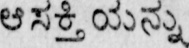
ಆಸಕ್ತಿಯನ್ನು
